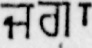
ਜਗਾ
